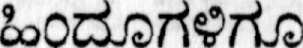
ಹಿಂದೂಗಳಿಗೂ
